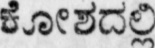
ಕೋಶದಲ್ಲಿ
